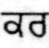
ਕਰ
